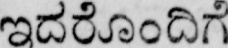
ಇದರೊಂದಿಗೆ
